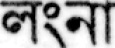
লংনা
